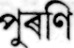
পুৰণি
